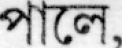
পালে,
